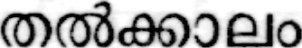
തല്‍ക്കാലം
